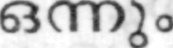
ഒന്നും
